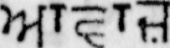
ਆਵਾਜ਼
